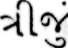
ત્રીજું
